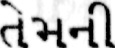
તેમની
